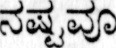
ನಷ್ಟವೂ
